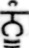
ਨੂੰ
